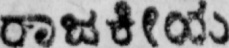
ರಾಜಕೀಯ
